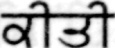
ਕੀਤੀ
